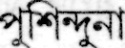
পুশিন্দুনা
